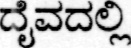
ದೈವದಲ್ಲಿ
